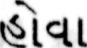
હોવા
